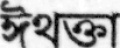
ঈথক্তা
